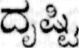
ದೃಷ್ಟಿ
